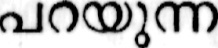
പറയുന്ന
